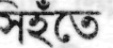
সিহঁতে
